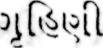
ગૃહિણી
